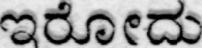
ಇರೋದು
